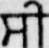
ਸੀ
